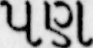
પણ
